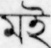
মই
